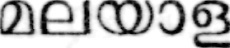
മലയാള
